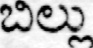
ಬಿಲ್ಲು
